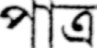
পাত্র
